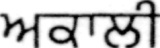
ਅਕਾਲੀ
